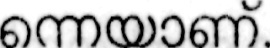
ന്നെയാണ്.
